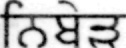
ਨਿਬੇੜ
